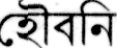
হৌবনি
